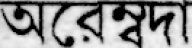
অরেম্বদা
